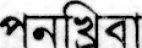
পনখ্রিবা
